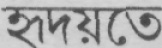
হৃদয়তে
